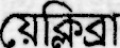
য়েক্লিব্রা
